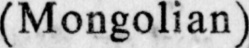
(Mongolian)
